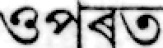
ওপৰত
